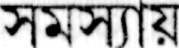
সমস্যায়
